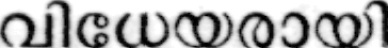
വിധേയരായി
